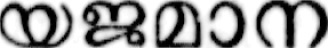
യജമാന
